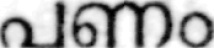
പണം
